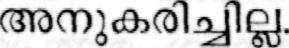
അനുകരിച്ചില്ല.
